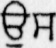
ਉਸ
